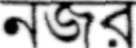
নজর
